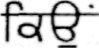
ਕਿਉਂ
